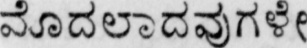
ಮೊದಲಾದವುಗಳೇ
